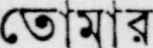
তোমার
